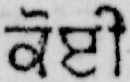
ਕੋਈ
